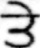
ਤੇ
